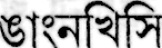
ঙাংনখিসি
